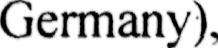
Germany),
